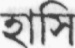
হাসি
